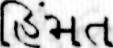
હિંમત
